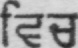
ਵਿਚ
